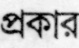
প্রকার
